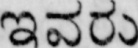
ಇವರು
